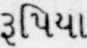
રૂપિયા
